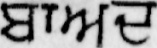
ਬਾਅਦ
